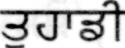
ਤੁਹਾਡੀ
